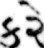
કરે
